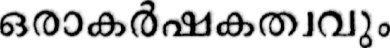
ഒരാകര്‍ഷകത്വവും
